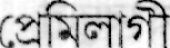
প্রেমিলাগী
